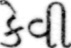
કેવી
